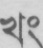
খং
